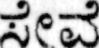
ಸೇವೆ
